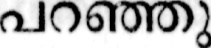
പറഞ്ഞു
